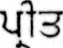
ਪ੍ਰੀਤ
